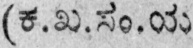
(ಕ.ಖ.ಸಂ.ಯ
